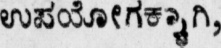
ಉಪಯೋಗಕ್ಕಾಗಿ,
